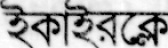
ইকাইরক্লে
